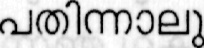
പതിന്നാലു
